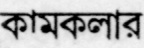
কামকলার
